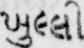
ખુલ્લી
